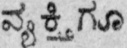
ವ್ಯಕ್ತಿಗೂ
